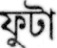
ফুটা
